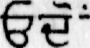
ਓਦੋਂ
